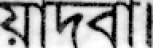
য়াদবা।
